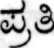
ಪ್ರತಿ
